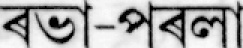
ৰভা-পৰলা
